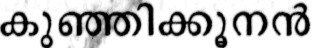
കുഞ്ഞിക്കൂനന്‍
